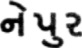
નેપુર
